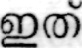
ഇത്
